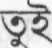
তুই
